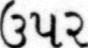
ઉપર
